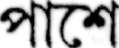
পাশে
